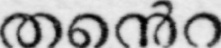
തന്റെ
